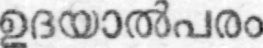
ഉദയാല്‍പരം
